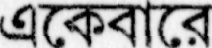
একেবারে
